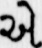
એ
